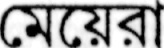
মেয়েরা
